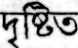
দৃষ্টিত
